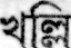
খল্লি
